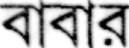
বাবার
